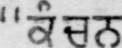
''ਕੰਚਨ
